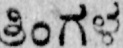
ತಿಂಗಳ
